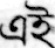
এই
